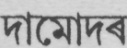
দামোদৰ
